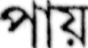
পায়
